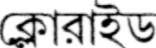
ক্লোরাইড
